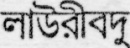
লাউরিবদু
